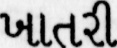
ખાતરી
